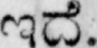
ಇದೆ.
